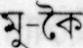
মু-কৈ
